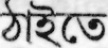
ঠাইতে
